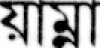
য়াম্না
